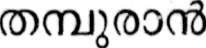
തമ്പുരാന്‍
